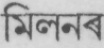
মিলনৰ
